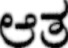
ಆತ
